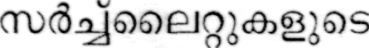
സര്‍ച്ച്‌ലൈറ്റുകളുടെ
